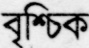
বৃশ্চিক
